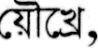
য়ৌখ্রে,
